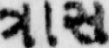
ત્રાસ
